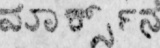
ಮಾರ್ಕ್ಸ್ನ
